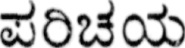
ಪರಿಚಯ
